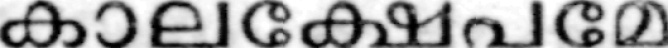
കാലക്ഷേപമേ
